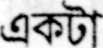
একটা
